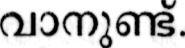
വാനുണ്ട്.
